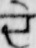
ਦੇ
